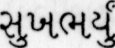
સુખભર્યું
